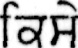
ਕਿਸੇ
